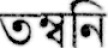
তম্বনি
